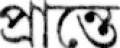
প্রান্তে
